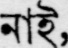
নাই,
